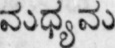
ಮಧ್ಯಮ
